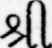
શ્રી
